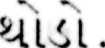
થોડો.
